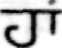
ਹਾਂ
